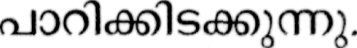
പാറിക്കിടക്കുന്നു.
